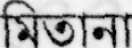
মিতানা
